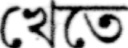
খেতে
